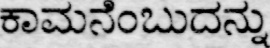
ಕಾಮನೆಂಬುದನ್ನು
